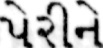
પેરીને
